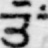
ਤੋਂ
